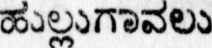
ಹುಲ್ಲುಗಾವಲು
